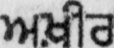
ਅਖ਼ੀਰ
